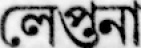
লেপ্তনা
